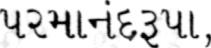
પરમાનંદપા,
